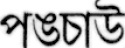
পঙচাউ
